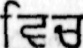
ਵਿਚ
